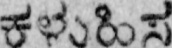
ಕಳುಹಿಸ
